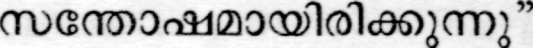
സന്തോഷമായിരിക്കുന്നു”
